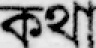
কথা
